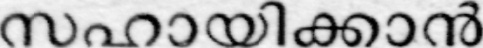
സഹായിക്കാന്‍
